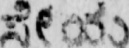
ಸೇಯ
